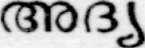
അദ്യ
